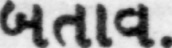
બતાવ.
